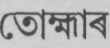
তোহ্মাৰ
